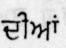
ਦੀਆਂ
